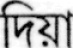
দিয়া
